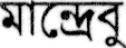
মান্দেবু
